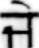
ਜੇ
